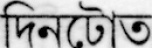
দিনটোত
